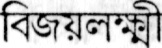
বিজয়লক্ষ্মী
